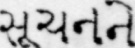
સૂચનને
